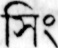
সিং
